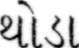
થોડા
